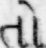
તો
